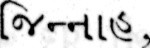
જિન્નાહ,
